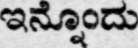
ಇನ್ನೊ೦ದು
